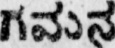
ಗಮನ
